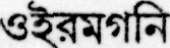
ওইরমগনি
